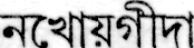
নখোয়গীদা
